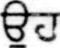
ਉਹ
